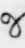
જ
